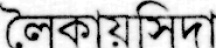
লৈকায়সিদা
